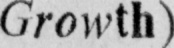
Growth)
